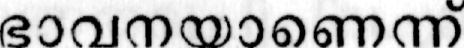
ഭാവനയാണെന്ന്
